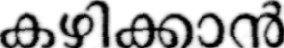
കഴിക്കാന്‍
